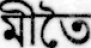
মীতৈ
